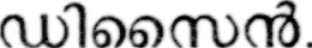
ഡിസൈന്‍.
